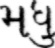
મધુ
